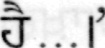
ਹੈ...।'
